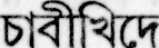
চাবীখিদে
